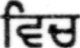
ਵਿਚ
